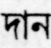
দান
